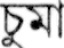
চুমা
